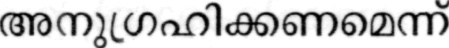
അനുഗ്രഹിക്കണമെന്ന്
